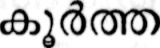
കൂര്‍ത്ത
